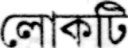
লোকটি
